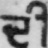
ਦੀ
